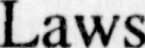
Laws
